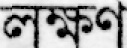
লক্ষণ
